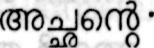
അച്ഛന്റെ
